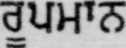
ਰੂਪਮਾਨ
